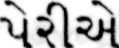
પેરીએ
